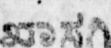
ಖಾಸಗಿ
